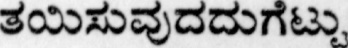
ತಯಿಸುವುದದುಗೆಟ್ಟು
